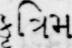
કૃત્રિમ
